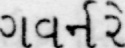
ગવર્નરે
